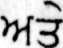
ਅਤੇ
